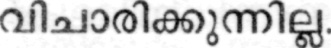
വിചാരിക്കുന്നില്ല.
